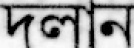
দলান
